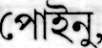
পোইনু,
